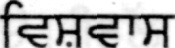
ਵਿਸ਼ਵਾਸ
